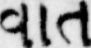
વાત
